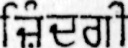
ਜ਼ਿੰਦਗੀ
